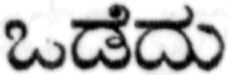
ಒಡೆದು
